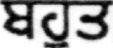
ਬਹੁਤ
